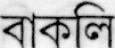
বাকলি
